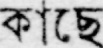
কাছে
